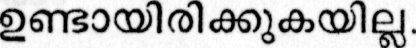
ഉണ്ടായിരിക്കുകയില്ല.
